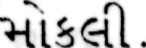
મોકલી.
